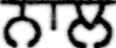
ਨਾਲ
